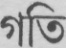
গতি
